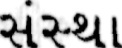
સંસ્થા
